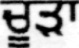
ਚੂੜਾ
